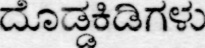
ದೊಡ್ಡಕಿಡಿಗಳು
